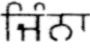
ਜਿੰਨਾ
